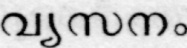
വ്യസനം
